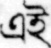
এই
